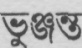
ভুঞ্জন্ত
